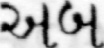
અબ
